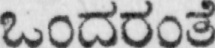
ಒಂದರಂತೆ
